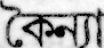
কৈন্যা
